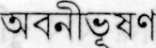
অবনীভূষণ
